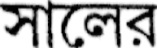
সালের
